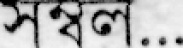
সম্বল...
